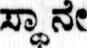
ಸ್ಥಾನೇ
